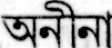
অনীনা
